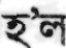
হ'ল
